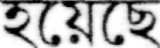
হয়েছে
